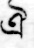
ঐ
